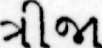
ત્રીજા
